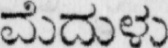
ಮೆದುಳು
